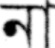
না
